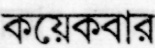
কয়েকবার
